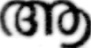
ആ
